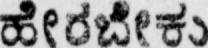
ಹೇರಬೇಕು
